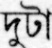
দুটা
